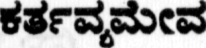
ಕರ್ತವ್ಯಮೇವ
